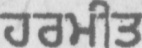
ਹਰਮੀਤ
